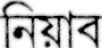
নিয়াব
